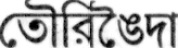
তৌরিঙৈদা
